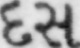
દસ
